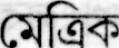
মেত্রিক
